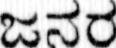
ಜನರ
